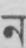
ন
